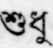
শুধু
